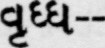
વૃધ્ધ-
